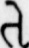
તે
